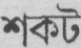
শকট
